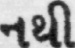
નથી
